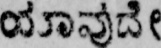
ಯಾವುದೇ
